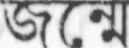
জন্মে
